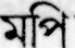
মপি
